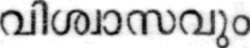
വിശ്വാസവും
